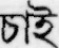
চাই
